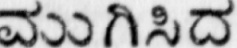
ಮುಗಿಸಿದ
